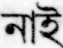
নাই
